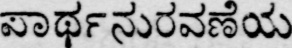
ಪಾರ್ಥನುರವಣೆಯ
